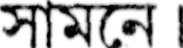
সামনে।
